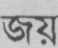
জয়
